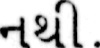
નથી.
